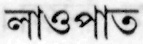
লাওপাত
